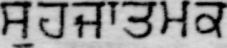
ਸੁਹਜਾਤਮਕ
